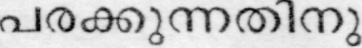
പരക്കുന്നതിനു
